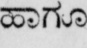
ಹಾಗೂ
